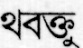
থবক্তু
